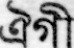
ঐগী
